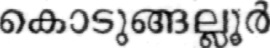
കൊടുങ്ങല്ലൂര്‍
